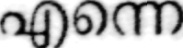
എന്നെ
